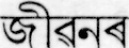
জীৱনৰ
